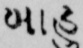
બાહુ
